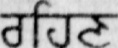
ਰਹਿਣ
